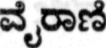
ವೈರಾಣಿ
